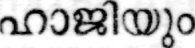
ഹാജിയും
